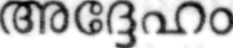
അദ്ദേഹം
